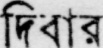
দিবার
